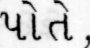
પોતે,
